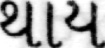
થાય
